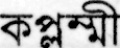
কপ্লম্মী
